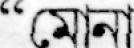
“মোনা
